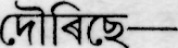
দৌৰিছে-
